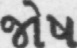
જોષ
